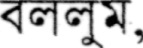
বললুম,
